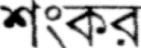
শংকর
